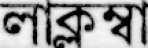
লাক্লম্বা
